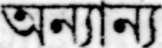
অন্যান্য
